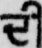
ਦੀ
